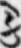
કે
